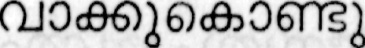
വാക്കുകൊണ്ടു
